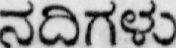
ನದಿಗಳು
